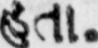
હતા.
